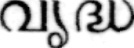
വൃദ്ധ
